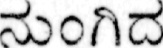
ನುಂಗಿದ
